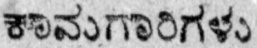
ಕಾಮಗಾರಿಗಳು
